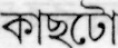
কাছটো
